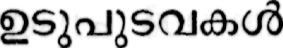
ഉടുപുടവകള്‍
